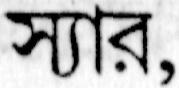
স্যার,
